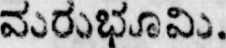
ಮರುಭೂಮಿ.
